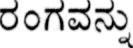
ರಂಗವನ್ನು
